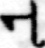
ન
